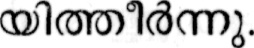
യിത്തീര്‍ന്നു.
